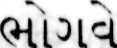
ભોગવે
